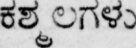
ಕಶ್ಮಲಗಳು
